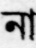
না
